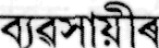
ব্যৱসায়ীৰ
